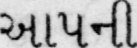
આપની
